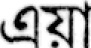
এয়া
